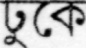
ঢুকে
